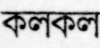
কলকল
